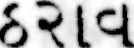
ઠરાવ
